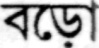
বড়ো
